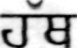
ਹੱਥ
